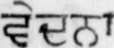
ਵੇਦਨਾ
